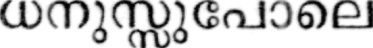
ധനുസ്സുപോലെ
